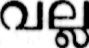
വല്ല
